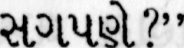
સગપણે?"
